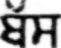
ਬੱਸ
